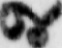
જ
